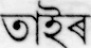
তাইৰ
